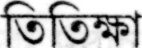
তিতিক্ষা
